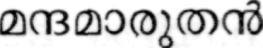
മന്ദമാരുതന്‍
